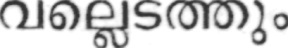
വല്ലെടത്തും
